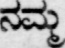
ನಮ್ಮ
